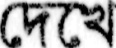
দেখে
